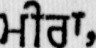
ਮੀਰਾ,
